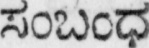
ಸಂಬಂಧ
